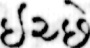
ઈચ્છે
